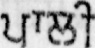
ਪਾਲੀ
